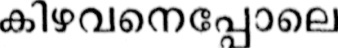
കിഴവനെപ്പോലെ
